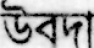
উবদা
